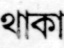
থাকা
